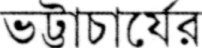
ভট্টাচার্যের
